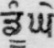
ਡੂੰਘੇ
